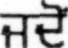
ਜਦੋਂ
